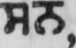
ਸਨ,
